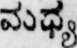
ಮಧ್ಯ
